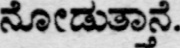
ನೋಡುತ್ತಾನೆ.
